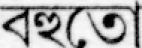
বহুতো
